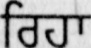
ਰਿਹਾ
